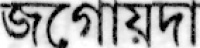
জগোয়দা
